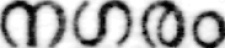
നഗരം
